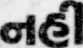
નહી
